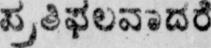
ಪ್ರತಿಫಲವಾದರೆ
